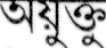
অয়ুক্তু
